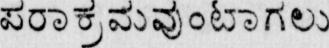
ಪರಾಕ್ರಮವುಂಟಾಗಲು
